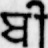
ਬੀ
